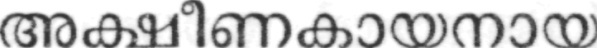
അക്ഷീണകായനായ
